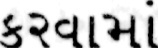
કરવામાં
